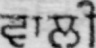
ਵਾਲੀ
